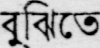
বুঝিতে
